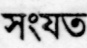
সংযত
